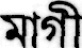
মাগী
